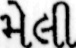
મેલી
